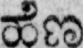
ಹೆಣ
